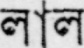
লাল
